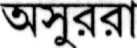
অসুররা
